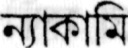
ন্যাকামি
